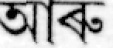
আৰু
